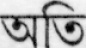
অতি
